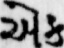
એક
